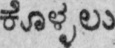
ಕೊಳ್ಳಲು
